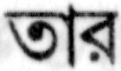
তার
